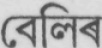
বেলিৰ
